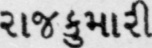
રાજકુમારી
